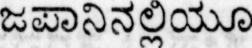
ಜಪಾನಿನಲ್ಲಿಯೂ
